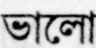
ভালো
